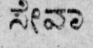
ಸೇವಾ
